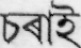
চৰাই
